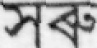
সৰু
